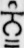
ਨੂੰ
